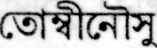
তোম্বীনৌসু
